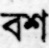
বশ
